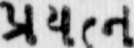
પ્રયત્ન
